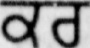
ਕਰ
